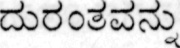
ದುರಂತವನ್ನು
